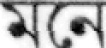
মনে
